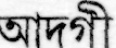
আদগী
